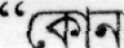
"কোন
